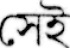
সেই
